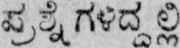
ಪ್ರಶ್ನೆಗಳಿದ್ದಲ್ಲಿ
